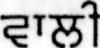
ਵਾਲੀ
